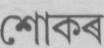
শোকৰ
